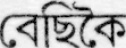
বেছিকৈ
